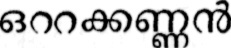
ഒററക്കണ്ണന്‍
